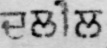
ਦਲੀਲ
